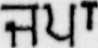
ਜਪਾ
